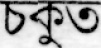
চকুত
